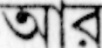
আর
